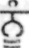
ਨੂੰ
